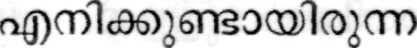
എനിക്കുണ്ടായിരുന്ന
